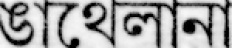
ঙাথেলানা
